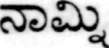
ನಾಮ್ನಿ
